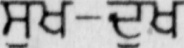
ਸੁਖ-ਦੁਖ
